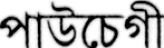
পাউচেগী
